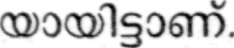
യായിട്ടാണ്.
